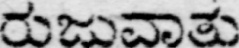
ರುಜುವಾತು
